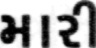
મારી
